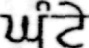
ਘੰਟੇ
